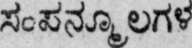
ಸಂಪನ್ಮೂಲಗಳ
